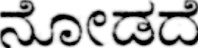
ನೋಡದೆ
